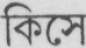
কিসে
